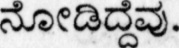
ನೋಡಿದ್ದೆವು.
